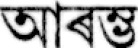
আৰম্ভ
